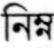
নিম্ন
